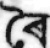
ৰৈ
